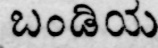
ಬಂಡಿಯ
